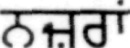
ਨਜ਼ਰਾਂ
